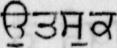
ਉਤਸੁਕ
